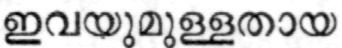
ഇവയുമുള്ളതായ
